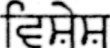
ਵਿਸ਼ੇਸ਼
